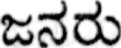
ಜನರು
